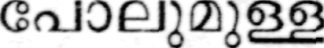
പോലുമുള്ള
